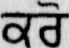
ਕਰੋ
